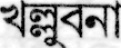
খল্লুবনা
